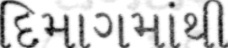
દિમાગમાંથી
